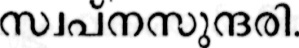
സ്വപ്നസുന്ദരി.
